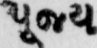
પૂજ્ય
